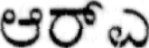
ಆರ್ಎ
